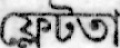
ফ্লেটতা
